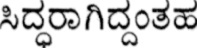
ಸಿದ್ಧರಾಗಿದ್ದಂತಹ
